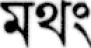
মথং
